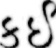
કઈ
